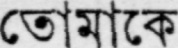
তোমাকে
